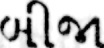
બીજા
